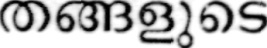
തങ്ങളുടെ
